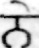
ਨੇ
